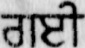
ਗਈ
